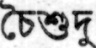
চৈশুদু
